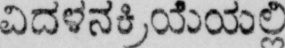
ವಿದಳನಕ್ರಿಯೆಯಲ್ಲಿ
